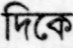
দিকে
